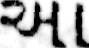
આ
